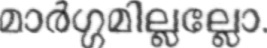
മാര്‍ഗ്ഗമില്ലല്ലോ.
